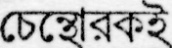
চেন্থোরকই
